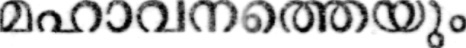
മഹാവനത്തെയും
